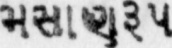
મસાણરૂપ
